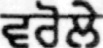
ਵਰੋਲੇ
